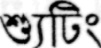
শ্যুটিং
